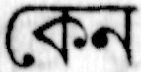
কেন
